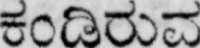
ಕಂಡಿರುವ
